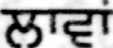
ਲਾਵਾਂ
